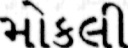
મોકલી
